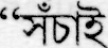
"সঁচাই
